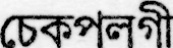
চেকপলগী
